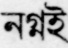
নগ্নই
